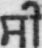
ਸੀ
